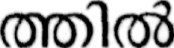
ത്തില്‍
